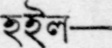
হইল—
